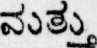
ಮತ್ತು
